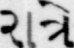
રાત્રે
